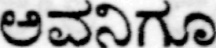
ಅವನಿಗೂ
